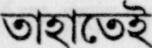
তাহাতেই
